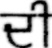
ਦੀ
